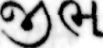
જીભ
